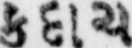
કદાચ
